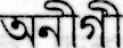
অনীগী
